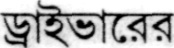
ড্রাইভারের
